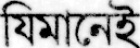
যিমানেই
